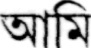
আমি
